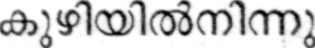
കുഴിയില്‍നിന്നു
